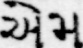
એમ
